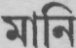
মানি
